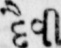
દૈવી
